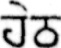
ਹੇਠ
